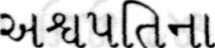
અશ્વપતિના
